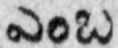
ಎಂಬ
